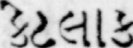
કેટલાક
